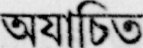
অযাচিত
